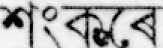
শংকৰে
